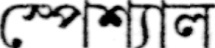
স্পেশ্যাল
